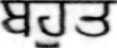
ਬਹੁਤ
